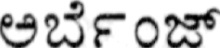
ಅರ್ಬೆಂಜ್
